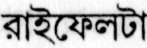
রাইফেলটা
